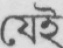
যেই
